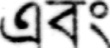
এবং
